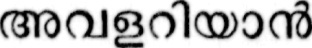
അവളറിയാന്‍
